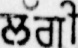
ਲੱਗੀ
